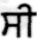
ਸੀ
